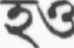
হও
